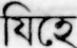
যিহে
